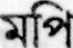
মপি
